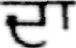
ਦਾ
